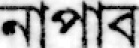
নাপাব
